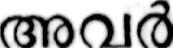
അവര്‍
